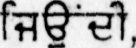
ਜਿਉਂਦੀ,
